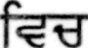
ਵਿਚ
